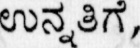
ಉನ್ನತಿಗೆ,
